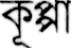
কূপ্পা
